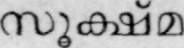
സൂക്ഷ്മ
